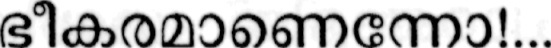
ഭീകരമാണെന്നോ!...
